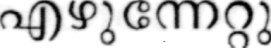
എഴുന്നേറ്റു
